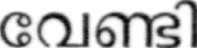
വേണ്ടി
